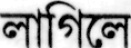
লাগিলে
